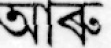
আৰু
